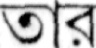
তার
